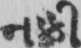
નક્કી
